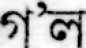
গ'ল
